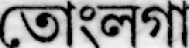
তোংলগা
